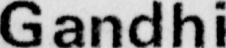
Gandhi
